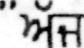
''ਅੱਜ
